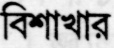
বিশাখার
